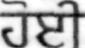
ਹੋਈ
